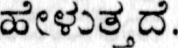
ಹೇಳುತ್ತದೆ.
